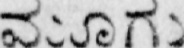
ಮೂಗು
